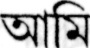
আমি
